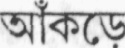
আঁকড়ে
